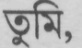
তুমি,
